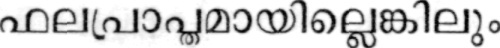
ഫലപ്രാപ്തമായില്ലെങ്കിലും
